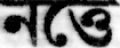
নত্তে
